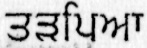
ਤੜਪਿਆ
